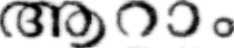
ആറാം
